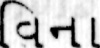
વિના
